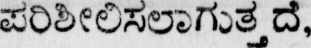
ಪರಿಶೀಲಿಸಲಾಗುತ್ತದೆ,
